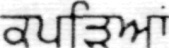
ਕਪੜਿਆਂ
